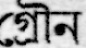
গ্রৌন
